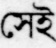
সেই
